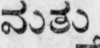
ಮತ್ತು
